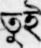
তুই
